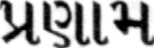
પ્રણામ
